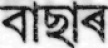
বাছাৰ
